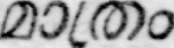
മാത്രം
